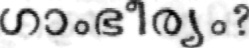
ഗാംഭീര്യം?
